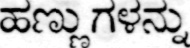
ಹಣ್ಣುಗಳನ್ನು
